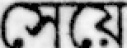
সেয়ে
